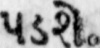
પડશે.
